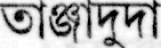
তাঞ্জাদুদা
